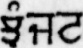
ਝੰਜਟ
